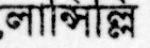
লোন্সিল্লি
